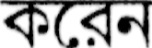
করেন
